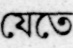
যেতে
